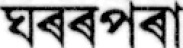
ঘৰৰপৰা
